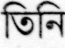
তিনি
